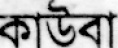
কাউবা
